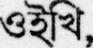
ওইখি,
